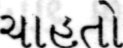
ચાહતો
